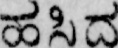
ಹಸಿದ
